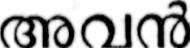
അവന്‍
